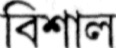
বিশাল
